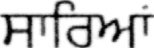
ਸਾਰਿਆਂ
